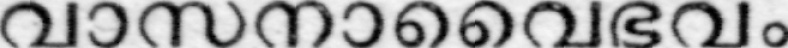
വാസനാവൈഭവം
